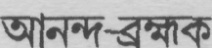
আনন্দ-ব্ৰহ্মক
